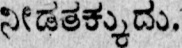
ನೀಡತಕ್ಕುದು.
